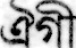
ঐগী
